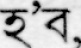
হ'ব,
